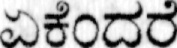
ಏಕೆಂದರೆ
